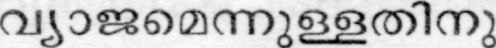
വ്യാജമെന്നുള്ളതിനു
